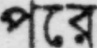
পরে
